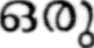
ഒരു
